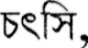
চৎসি,
